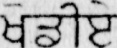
ਖੋਡੀਏ
